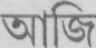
আজি
